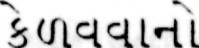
કેળવવાનો
